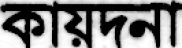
কায়দনা
